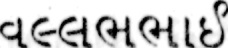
વલ્લભભાઈ
